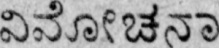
ವಿಮೋಚನಾ
